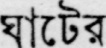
ঘাটের
